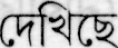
দেখিছে
